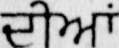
ਦੀਆਂ
